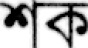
শক
